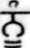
ਨੂੰ
